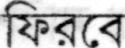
ফিরবে
